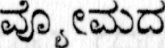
ವ್ಯೋಮದ
